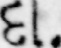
દા.
